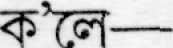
ক'লে-
